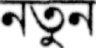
নতুন
